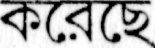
করেছে
